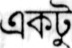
একটু
